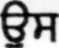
ਉਸ
